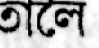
তালৈ
